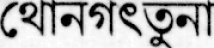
থোনগৎতুনা
